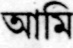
আমি
